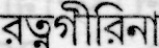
রত্নগীরিনা
